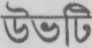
উভটি
